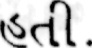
હતી.
